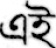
এই
